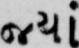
જ્યાં
